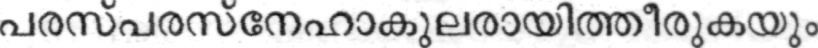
പരസ്പരസ്നേഹാകുലരായിത്തീരുകയും
